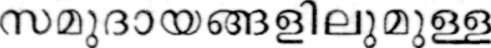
സമുദായങ്ങളിലുമുള്ള
